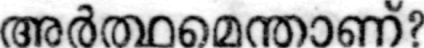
അര്‍ത്ഥമെന്താണ്?
